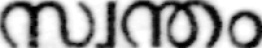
സ്വന്തം
